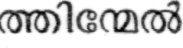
ത്തിന്മേല്‍
